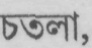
চতলা,
